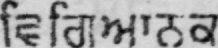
ਵਿਗਿਆਨਕ
